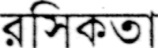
রসিকতা
